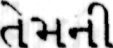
તેમની
